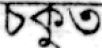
চকুত
